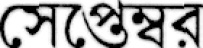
সেপ্তেম্বর
